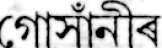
গোসাঁনীৰ
